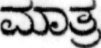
ಮಾತ್ರ
